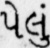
પેલું
